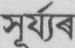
সূৰ্য্যৰ
